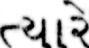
ત્યારે
